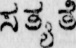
ಸತ್ಯತೆ
